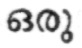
ഒരു
